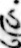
હું
